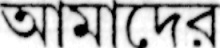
আমাদের
